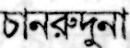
চানরুদুনা
